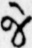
જે
